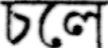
চলে
